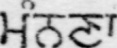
ਮੰਨਣਾ
